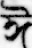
ঈ
